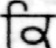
ਕਿ
